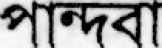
পান্দবা
